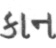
કાન
